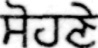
ਸੋਹਣੇ
